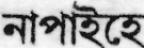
নাপাইহে
